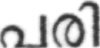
പരി
